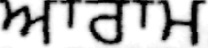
ਆਰਾਮ
